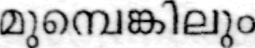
മുമ്പെങ്കിലും
